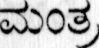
ಮಂತ್ರ
